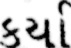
કર્યા
